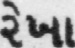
રેખા
